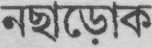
নছাড়োক
